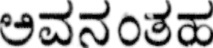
ಅವನಂತಹ
